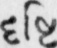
દષ્ટિ
